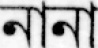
নানা
